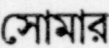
সোমার
